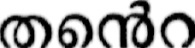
തന്റെ
